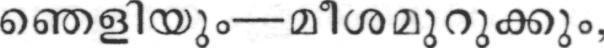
ഞെളിയും-മീശമുറുക്കും,
